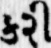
કરી
